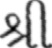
શ્રી
